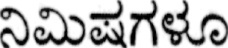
ನಿಮಿಷಗಳೂ
